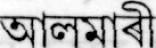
আলমাৰী
